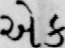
એક
